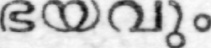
ഭയവും
